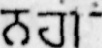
ਨਹੀਂ
